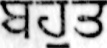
ਬਹੁਤ
